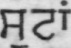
ਸੁਟਾਂ
